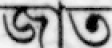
জাত
